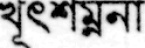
খূৎশম্ননা
